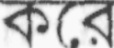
করে
